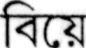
বিয়ে
